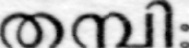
തമ്പി:
